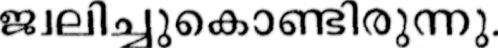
ജ്വലിച്ചുകൊണ്ടിരുന്നു.
